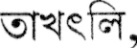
তাখৎলি,
